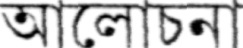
আলোচনা
